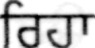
ਰਿਹਾ
